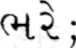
ભરે;
